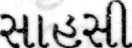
સાહસી
